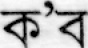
ক'ব
